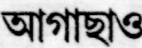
আগাছাও
